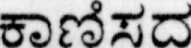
ಕಾಣಿಸದ
